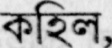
কহিল,
